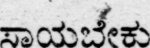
ಸಾಯಬೇಕು
